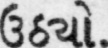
ઉઠ્યો.
